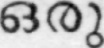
ഒരു
